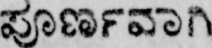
ಪೂರ್ಣವಾಗಿ
